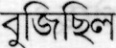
বুজিছিল
